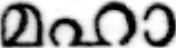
മഹാ
